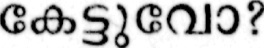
കേട്ടുവോ?
